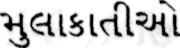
મુલાકાતીઓ
